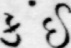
કંઈ
